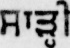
ਸਾੜ੍ਹੀ
